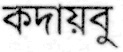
কদায়বু
